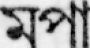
মপা
